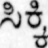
ಸಿಕ್ಕಿ
